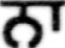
ਨਾ
